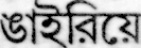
ঙাইরিয়ে
